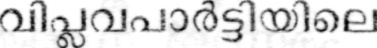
വിപ്ലവപാര്‍ട്ടിയിലെ
